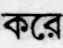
করে
